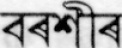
বৰশীৰ
